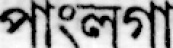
পাংলগা
